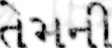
તેમની
